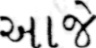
આજે
